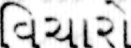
વિચારો
